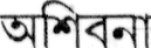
অশিবনা
